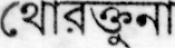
থোরক্তুনা
